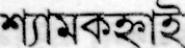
শ্যামকহ্ণাই
